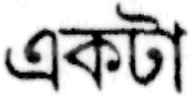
একটা
